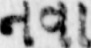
નવા
